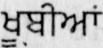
ਖੂਬੀਆਂ
